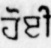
ਹੋਈ
